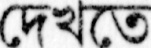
দেখতে
